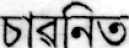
চাৱনিত
